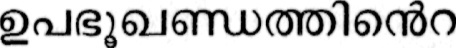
ഉപഭൂഖണ്ഡത്തിന്റെ
